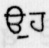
ਉਹ
